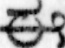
ಈ
